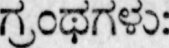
ಗ್ರಂಥಗಳು:
